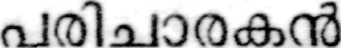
പരിചാരകന്‍
